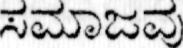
ಸಮಾಜವು
